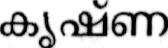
കൃഷ്ണ
